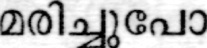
മരിച്ചുപോ
